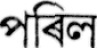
পৰিল
